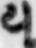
ય
